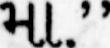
મા."
